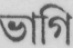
ভাগি
